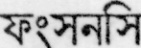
ফংসনসি
